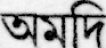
অমদি
